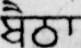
ਬੈਠਾ
